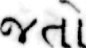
જતો
